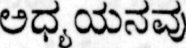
ಅಧ್ಯಯನವು
